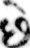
છે
